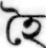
হৈ
